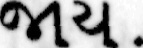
જાય.
